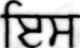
ਇਸ
